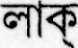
লাক্
